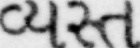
વ્યસ્ત
